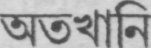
অতখানি
